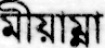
মীয়াম্না
